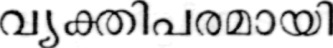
വ്യക്തിപരമായി
